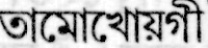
তামোখোয়গী
